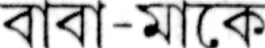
বাবা-মাকে
